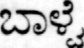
ಬಾಳ್ವೆ
